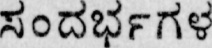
ಸಂದರ್ಭಗಳ
